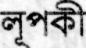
লূপকী
